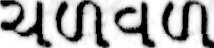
ચળવળ
